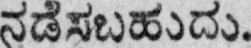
ನಡೆಸಬಹುದು.
